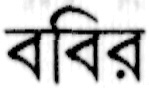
ববির
